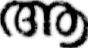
ആ
